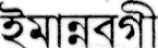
ইমান্নবগী
